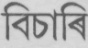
বিচাৰি
